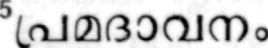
5പ്രമദാവനം
